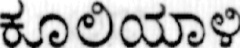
ಕೂಲಿಯಾಳಿ
